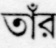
তাঁর
